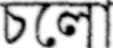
চলো
